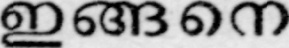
ഇങ്ങനെ
